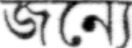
জন্যে
